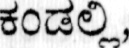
ಕಂಡಲ್ಲಿ,
